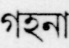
গহনা
